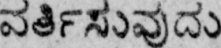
ವರ್ತಿಸುವುದು
